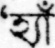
‘হ্যাঁ
